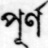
পূর্ণ
